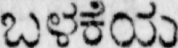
ಬಳಕೆಯ
